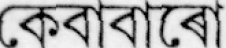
কেবাবাৰো
